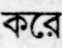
করে
